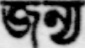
জন্য
